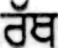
ਰੱਥ
